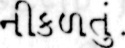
નીકળતું.
